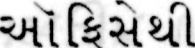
ઑફિસેથી
